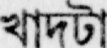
খাদটা
